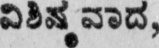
ವಿಶಿಷ್ಠವಾದ,
